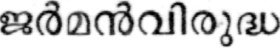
ജര്‍മന്‍വിരുദ്ധ
